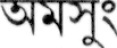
অমসুং
